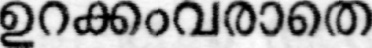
ഉറക്കംവരാതെ
